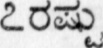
೭ರಷ್ಟು
